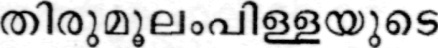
തിരുമൂലംപിള്ളയുടെ
